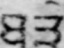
ਬੜੇ
